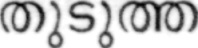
തുടുത്ത
